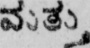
ಮತ್ತು
